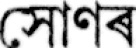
সোণৰ
